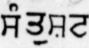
ਸੰਤੁਸ਼ਟ
